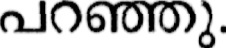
പറഞ്ഞു.
